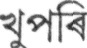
খুপৰি
